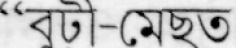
"বুঢ়ী-মেছত
